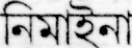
নিমাইনা
